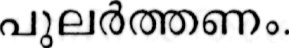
പുലര്‍ത്തണം.
